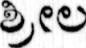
ಶ್ರೀಲ
